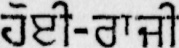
ਹੋਈ-ਰਾਜੀ
